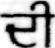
ਦੀ
